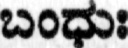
ಬಂಧುಃ
